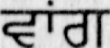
ਵਾਂਗ
